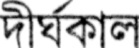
দীর্ঘকাল
